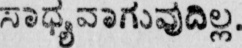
ಸಾಧ್ಯವಾಗುವುದಿಲ್ಲ.
